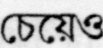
চেয়েও
